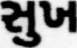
સુખ
